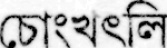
চোংখৎলি
